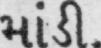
માંડી.
